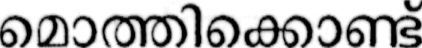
മൊത്തിക്കൊണ്ട്
